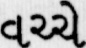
વચ્ચે
